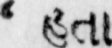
'હતા
